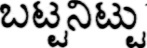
ಬಟ್ಟನಿಟ್ಟು
